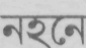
নহনে
